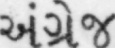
અંગ્રેજ
